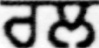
ਰਲ
